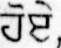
ਹੋਏ,
